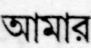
আমার
